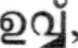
ഉവ്വ്,
